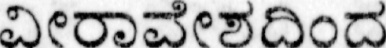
ವೀರಾವೇಶದಿಂದ
